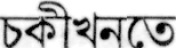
চকীখনতে
